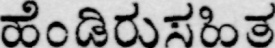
ಹೆಂಡಿರುಸಹಿತ
